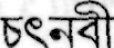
চৎনবী
